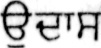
ਉਦਾਸ
